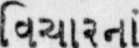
વિચારનાં
